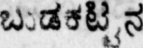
ಬುಡಕಟ್ಟಿನ
